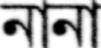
নানা
